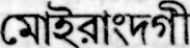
মোইরাংদগী
